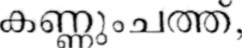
കണ്ണുംചത്ത്,
